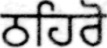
ਠਹਿਰੋ
